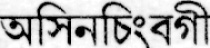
অসিনচিংবগী
